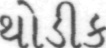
થોડીક
